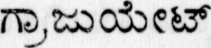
ಗ್ರಾಜುಯೇಟ್
